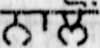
ਨਾਲੋਂ
